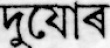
দুযোৰ
